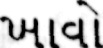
ખાવો
